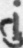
તું
